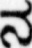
ನ
